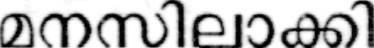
മനസിലാക്കി
